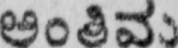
ಅಂತಿಮ
